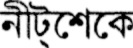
নীট্‌শেকে
